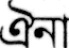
ঐনা
